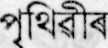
পৃথিৱীৰ
